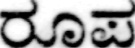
ರೂಪ
